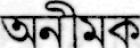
অনীমক
